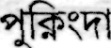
পুক্নিংদা
